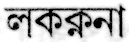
লকক্ননা
